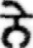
ਨੇ
